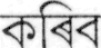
কৰিব
